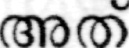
അത്
